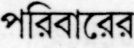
পরিবারের
